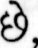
છે,
